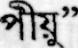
পীয়ু”
